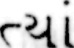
ત્યાં
